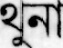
থুনা
